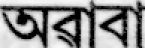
অৱাবা
